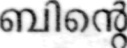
ബിന്റെ
